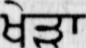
ਖੇੜਾ
